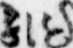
કોઈ
